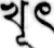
খূৎ
